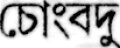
চোংবদু
